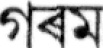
গৰম
